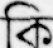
কি
